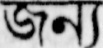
জন্য
